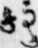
કરું
